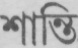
শান্তি
